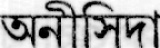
অনীসিদা
